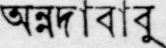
অন্নদাবাবু
